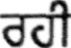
ਰਹੀ
